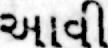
આવી
